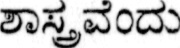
ಶಾಸ್ತ್ರವೆಂದು
